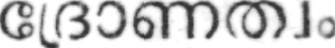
ദ്രോണത്വം
